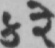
કરે
